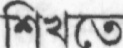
শিখতে
